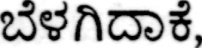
ಬೆಳಗಿದಾಕೆ,
